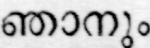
ഞാനും
